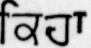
ਕਿਹਾ
